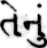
તેનું
